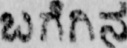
ಬಗೆಗಿನ
